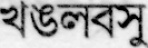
খঙলবসু
